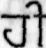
ਹੀ
